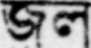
জল
